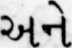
અને
